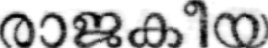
രാജകീയ
